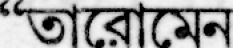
“তারোমেন
